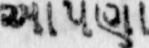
આપણા
